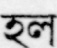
হল
